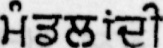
ਮੰਡਲਾਂਦੀ
